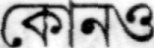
কোনও
